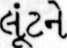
લૂંટને
